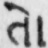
તો
